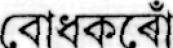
বোধকৰোঁ
